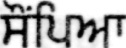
ਸੌਂਪਿਆ
